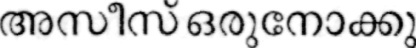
അസീസ്ഒരുനോക്കു
